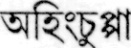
অহিংচুপ্পা
